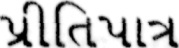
પ્રીતિપાત્ર
